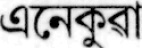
এনেকুৱা
